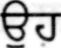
ਉਹ
